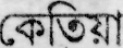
কেতিয়া
